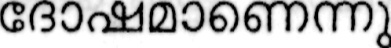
ദോഷമാണെന്നു
